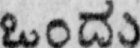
ಒಂದು
